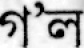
গ'ল
